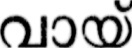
വായ്
